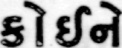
કોઈને
